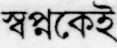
স্বপ্নকেই
